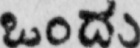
ಒಂದು
